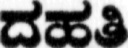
ದಹತಿ
